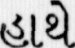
હાથે
